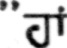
''ਹਾਂ
